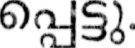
പ്പെട്ടു.
